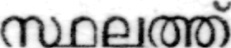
സ്ഥലത്ത്
